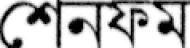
শেনফম
